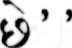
છે"
